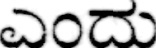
ಎಂದು
